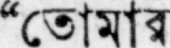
‘‘তোমার
